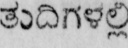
ತುದಿಗಳಲ್ಲಿ
